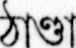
ঠাণ্ডা
